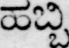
ಹಬ್ಬಿ
